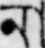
না
